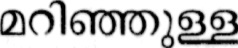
മറിഞ്ഞുള്ള
